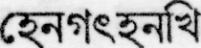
হেনগৎহনখি
